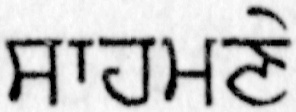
ਸਾਹਮਣੇ
